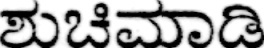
ಶುಚಿಮಾಡಿ
